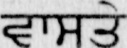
ਵਾਸਤੇ
